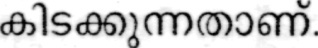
കിടക്കുന്നതാണ്.
